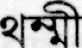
থম্মী
